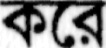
করে
